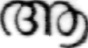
ആ
